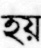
হয়
